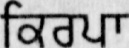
ਕਿਰਪਾ
